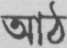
আঠ
